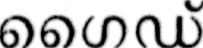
ഗൈഡ്
